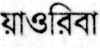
য়াওরিবা
